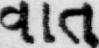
વાત
